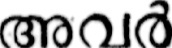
അവര്‍
